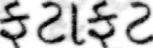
ફટાફટ
